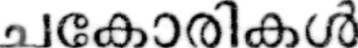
ചകോരികള്‍
